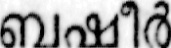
ബഷീര്‍
